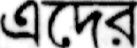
এদের
